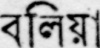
বলিয়া
